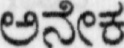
ಅನೇಕ
